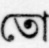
তো
